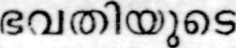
ഭവതിയുടെ
